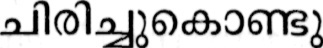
ചിരിച്ചുകൊണ്ടു
